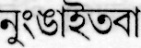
নুংঙাইতবা
